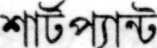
শার্টপ্যান্ট
